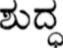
ಶುದ್ಧ
